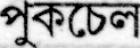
পুকচেল
